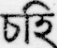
চহি
